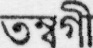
তম্বগী
